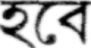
হবে
